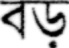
বড়
